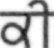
ਕੀ
